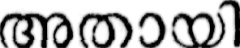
അതായി
